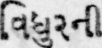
વિધુરની
